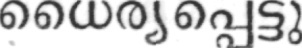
ധൈര്യപ്പെട്ടു
